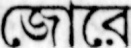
জোরে
